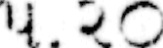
પ.૨૦
